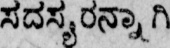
ಸದಸ್ಯರನ್ನಾಗಿ
